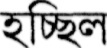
হচ্ছিল
